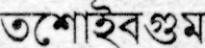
তশোইবগুম
